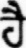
ਹੈ
